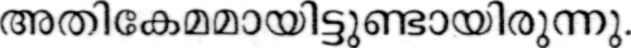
അതികേമമായിട്ടുണ്ടായിരുന്നു.
